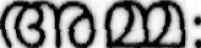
അമ്മ:
